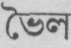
ভৈল
